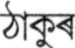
ঠাকুৰ
